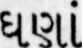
ઘણાં
